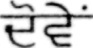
ਦੋਵੇਂ
